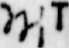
ਆ
